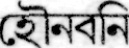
হৌনবনি
